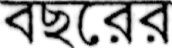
বছরের
